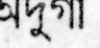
অদুগা
